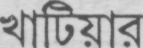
খাটিয়ার
